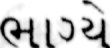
ભાગ્યે
